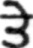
ਤੇ
